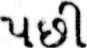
પછી
